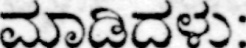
ಮಾಡಿದಳು:
